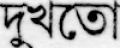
দুখতো
